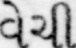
વેચી
